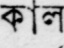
কাল
